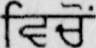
ਵਿਚੋਂ
